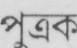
পুত্রক
